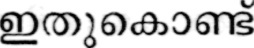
ഇതുകൊണ്ട്
